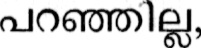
പറഞ്ഞില്ല,
